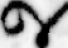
જ
